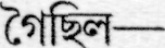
গৈছিল-
